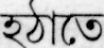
হঠাতে
